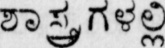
ಶಾಸ್ತ್ರಗಳಲ್ಲಿ
